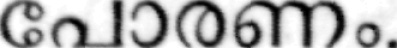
പോരണം.
